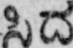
ಸಿದ
